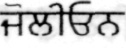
ਜੋਲੀਓਨ
